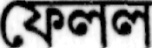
ফেলল
